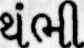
થંભી
